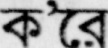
ক'রে
